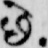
છે.
